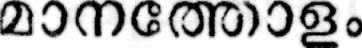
മാനത്തോളം
